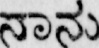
ನಾನು
